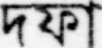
দফা
